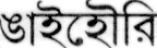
ঙাইহৌরি
